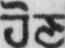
ਹੋਣ
